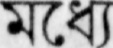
মধ্যে
